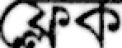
ফ্লেক
